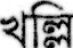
খল্লি
